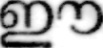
ഈ
